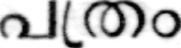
പത്രം
